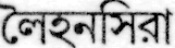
লৈহনসিরা
